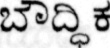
ಬೌದ್ಧಿಕ
